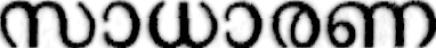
സാധാരണ
